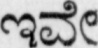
ಇವೇ
